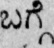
ಬಗ್ಗೆ
